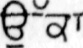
ਉੱਕਾ
